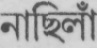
নাছিলাঁ
